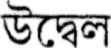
উদ্বেল
